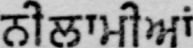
ਨੀਲਾਮੀਆਂ
